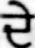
ਦੇ
